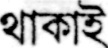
থাকাই
